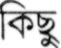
কিছু
